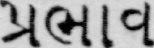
પ્રભાવ
